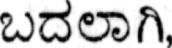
ಬದಲಾಗಿ,
